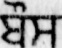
ਬੌਸ
